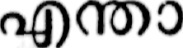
എന്താ
